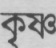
কৃষ্ণ
